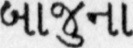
બાજુના
